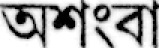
অশংবা
